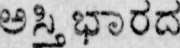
ಅಸ್ತಿಭಾರದ
